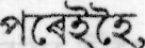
পৰেইহৈ,
